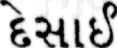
દેસાઈ
